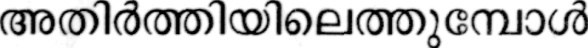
അതിര്‍ത്തിയിലെത്തുമ്പോള്‍
